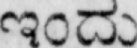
ಇಂದು
